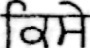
ਕਿਸੇ
